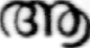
ആ
